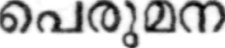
പെരുമന
